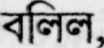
বলিল,
